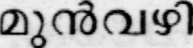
മുന്‍വഴി
